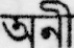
অনী
